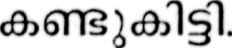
കണ്ടുകിട്ടി.
